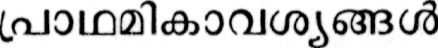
പ്രാഥമികാവശ്യങ്ങള്‍
